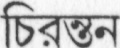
চিরন্তন
